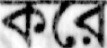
করে
